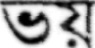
ভয়
